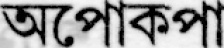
অপোকপা
